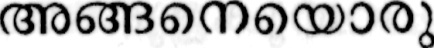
അങ്ങനെയൊരു
